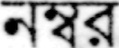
নম্বর
